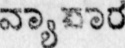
ವ್ಯಾಪಾರ
